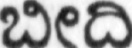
ಬೀದಿ
